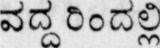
ವದ್ದರಿಂದಲ್ಲಿ
